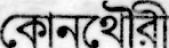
কোনথৌরী
